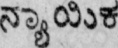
ನ್ಯಾಯಿಕ
